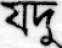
যদু
